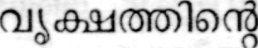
വൃക്ഷത്തിന്റെ
